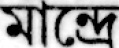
মান্দ্রে
